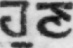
ਹੁਣ
